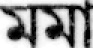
মমা
